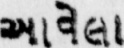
આવેલા
